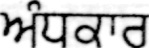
ਅੰਧਕਾਰ
